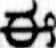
ಈ
